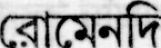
রোমেনদি
